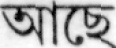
আছে
